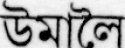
উমালৈ
